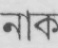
নাক
